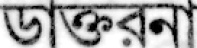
ডাক্তরনা
